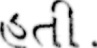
હતી,
